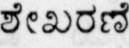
ಶೇಖರಣೆ
